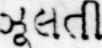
ઝૂલતી
